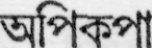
অপিকপা
